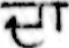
ਦਾ
